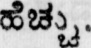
ಹೆಚ್ಚು.
